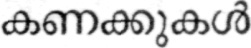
കണക്കുകള്‍
